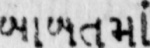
બાબતમાં
